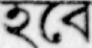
হবে
